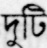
দুটি
